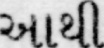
આથી
